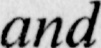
and
